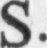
S.
